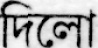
দিলো
